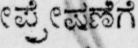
ಪ್ರೇಷಣೆಗೆ
